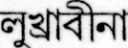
লুখ্রাবীনা
